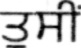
ਤੁਸੀਂ
